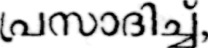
പ്രസാദിച്ച്,
